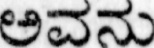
ಅವನು
